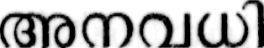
അനവധി
